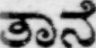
ತಾನೆ
